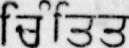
ਚਿੰਤਿਤ
